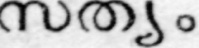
സത്യം
